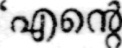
‘എന്റെ
